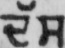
ਦੱਸ
